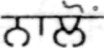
ਨਾਲੋਂ
